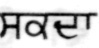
ਸਕਦਾ
